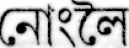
নোংলৈ
